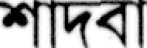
শাদবা
